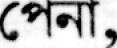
পেনা,
